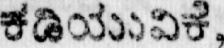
ಕಡಿಯುವಿಕೆ,
